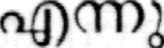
എന്നു
